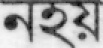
নহয়
